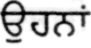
ਉਹਨਾਂ
